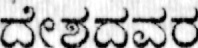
ದೇಶದವರ
